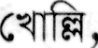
খোল্লি,
